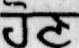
ਹੋਣ
